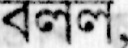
বলল,
